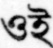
ওই
